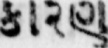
કારણ
